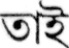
তাই
